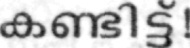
കണ്ടിട്ട്!
